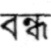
বন্ধ
